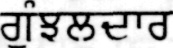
ਗੁੰਝਲਦਾਰ
